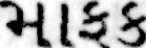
માફક
